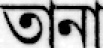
তানা
